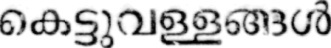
കെട്ടുവള്ളങ്ങള്‍
